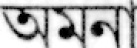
অমনা
